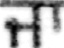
ਜਾ
